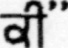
ਕੀ''
